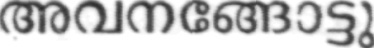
അവനങ്ങോട്ടു
